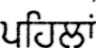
ਪਹਿਲਾਂ
